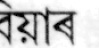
বিয়াৰ
